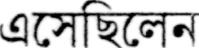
এসেছিলেন
